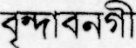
বৃন্দাবনগী
